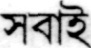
সবাই
